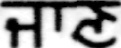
ਜਾਣ
